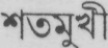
শতমুখী
